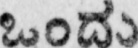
ಒಂದು
